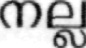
നല്ല
